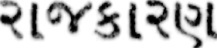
રાજકારણ
